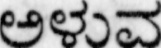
ಅಳುವ
